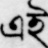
এই
